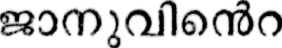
ജാനുവിന്റെ
